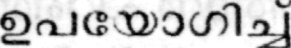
ഉപയോഗിച്ച്
